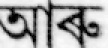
আৰু
